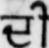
ਦੀ
